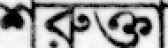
শরুক্তা
